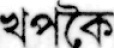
খপকৈ
